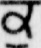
ਕੁ
